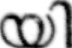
യി
